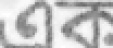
এক
